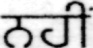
ਨਹੀਂ
